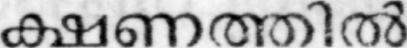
ക്ഷണത്തില്‍
